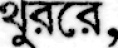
থুররে,
